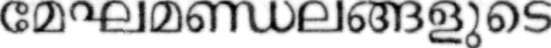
മേഘമണ്ഡലങ്ങളുടെ
